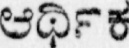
ಆರ್ಥಿಕ
